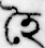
হৈ
